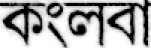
কংলবা
